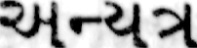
અન્યત્ર
